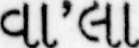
વા'લા
